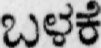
ಬಳಕೆ
